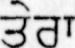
ਤੇਰਾ
